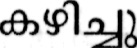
കഴിച്ചു
